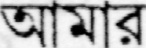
আমার
